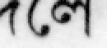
দলে
